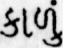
કાળું
